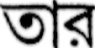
তার
